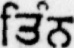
ਤਿੰਨ
